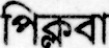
পিক্লবা
